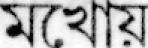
মখোয়
